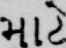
માટે
